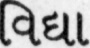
વિદ્યા
